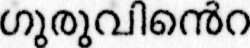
ഗുരുവിന്റെ
